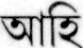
আহি
